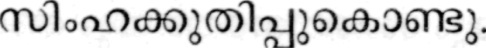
സിംഹക്കുതിപ്പുകൊണ്ടു.
